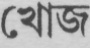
খোজ
